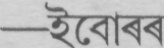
-ইবোৰৰ
